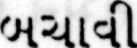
બચાવી
